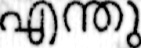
എന്തു
